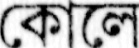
কোলে
